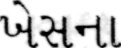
ખેસના
